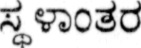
ಸ್ಥಳಾಂತರ
